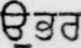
ਉਭਰ
